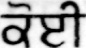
ਕੋਈ
